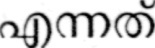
എന്നത്
